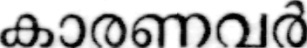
കാരണവര്‍
